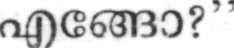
എങ്ങോ?"
